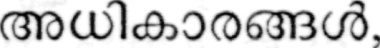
അധികാരങ്ങള്‍,
